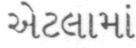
એટલામાં
